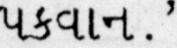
પકવાન.'
